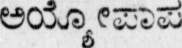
ಅಯ್ಯೋಪಾಪ
